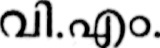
വി.എം.
